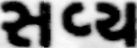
સવ્ય
